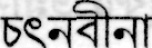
চৎনবীনা
